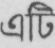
এটি
